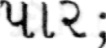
પાર;
